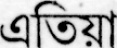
এতিয়া
